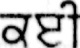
ਕਈ
